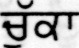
ਚੁੱਕਾ
